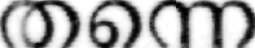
തന്നെ
